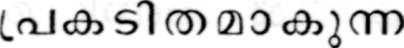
പ്രകടിതമാകുന്ന
